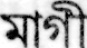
মাগী
